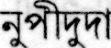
নুপীদুদা
